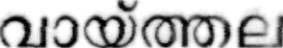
വായ്ത്തല
